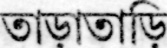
তাড়াতাড়ি
